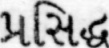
પ્રસિદ્ધ
